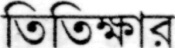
তিতিক্ষার
